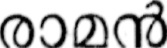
രാമന്‍
